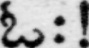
ಓ:!
